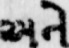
અને
